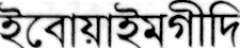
ইবোয়াইমগীদি
